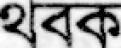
থবক
